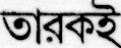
তারকই
